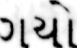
ગયો
